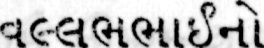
વલ્લભભાઈનો
